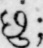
છું;
